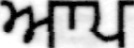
ਆਪ
